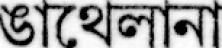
ঙাথেলনা
